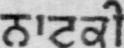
ਨਾਟਕੀ
